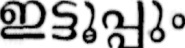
ഇട്ടൂപ്പും
